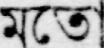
মতো
